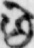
છે
